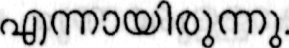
എന്നായിരുന്നു.
